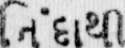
નિંદાથી
